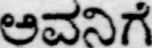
ಅವನಿಗೆ
